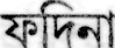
ফদিনা
